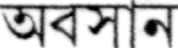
অবসান
